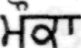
ਮੌਕਾ
